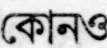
কোনও
